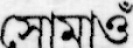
সোমাওঁ
